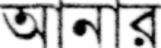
আনার
